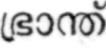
ഭ്രാന്ത്
